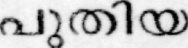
പുതിയ
